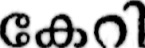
കേറി
